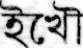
ইখৌ
